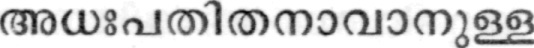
അധഃപതിതനാവാനുള്ള
